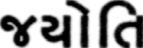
જ્યોતિ
